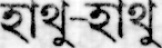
হাথু-হাথু
